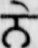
ਨੇ
